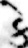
કે
